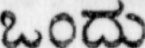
ಒಂದು
